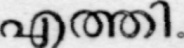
എത്തി.
